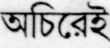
অচিরেই
